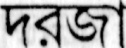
দরজা
